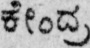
ಕೇಂದ್ರ
